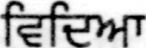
ਵਿਦਿਆ
